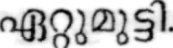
ഏറ്റുമുട്ടി.
